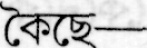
কৈছে-
